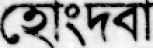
হোংদবা
